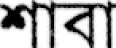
শাবা
